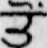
ਤੋਂ
